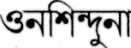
ওনশিন্দুনা
